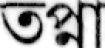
তপ্না
